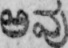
ಅವು
